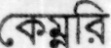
কেম্নরি
